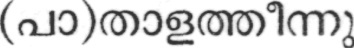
(പാ)താളത്തീന്നു
